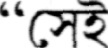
“সেই
